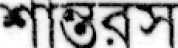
শান্তরস
